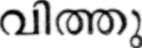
വിത്തു
